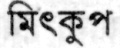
মিৎকুপ
